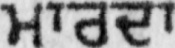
ਮਾਰਦਾ
